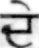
ਦੇ
